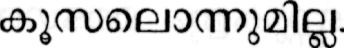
കൂസലൊന്നുമില്ല.
